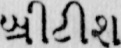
બ્રીટીશ
